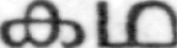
കഥ
